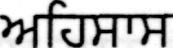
ਅਹਿਸਾਸ
